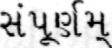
સંપૂર્ણમ્
